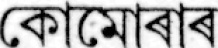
কোমোৰাৰ
